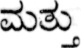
ಮತ್ತು
